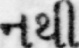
નથી
